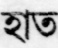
হাত
